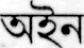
অইন
